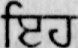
ਇਹ
